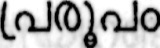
പ്രരൂപം
